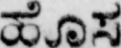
ಹೊಸ
